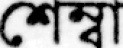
শেম্বা
